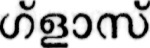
ഗ്ളാസ്
